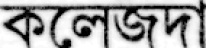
কলেজদা
